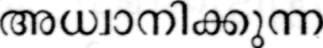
അധ്വാനിക്കുന്ന
